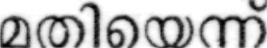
മതിയെന്ന്
